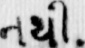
નથી.
